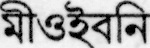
মীওইবনি
